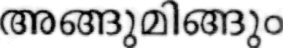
അങ്ങുമിങ്ങും
